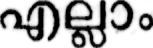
എല്ലാം
